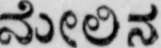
ಮೇಲಿನ
